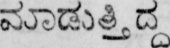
ಮಾಡುತ್ತಿದ್ದ
